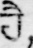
ਹੈ,
